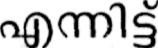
എന്നിട്ട്
